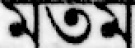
মতম
